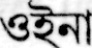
ওইনা
